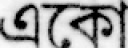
একো
